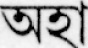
অহা
